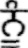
ਨੂੰ
